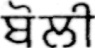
ਬੋਲੀ
